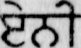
ਏਨੀ
